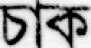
চাক
